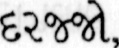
દરજ્જો,
